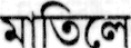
মাতিলে
